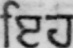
ਇਹ
